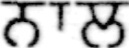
ਨਾਲ
